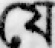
যে
